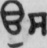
ਉਸ
